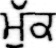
ਮੁੱਕ
